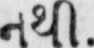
નથી.
